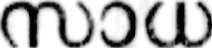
സാധ
